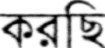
করছি
